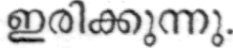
ഇരിക്കുന്നു.
